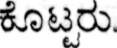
ಕೊಟ್ಟರು.
